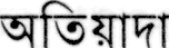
অতিয়াদা
